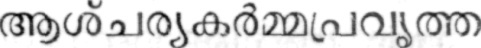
ആശ്ചര്യകര്‍മ്മപ്രവൃത്ത
